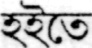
হইতে
